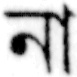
না
